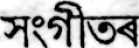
সংগীতৰ
